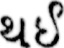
થઈ
